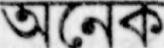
অনেক
